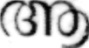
ആ
